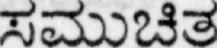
ಸಮುಚಿತ
